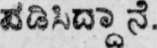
ಪಡಿಸಿದ್ದಾನೆ.
